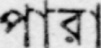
পারা
